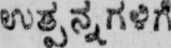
ಉತ್ಪನ್ನಗಳಿಗೆ
